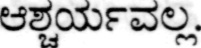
ಆಶ್ಚರ್ಯವಲ್ಲ.
